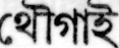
থৌগাই
